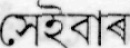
সেইবাৰ
